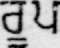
ਰੂਪ
